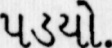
પડયો.
